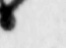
જ
